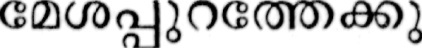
മേശപ്പുറത്തേക്കു
